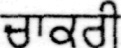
ਚਾਕਰੀ
